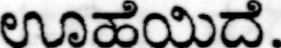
ಊಹೆಯಿದೆ.
